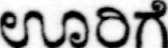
ಊರಿಗೆ
